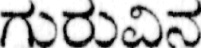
ಗುರುವಿನ
